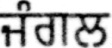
ਜੰਗਲ
